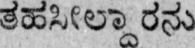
ತಹಸೀಲ್ದಾರನು
